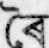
ৰৈ
